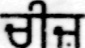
ਚੀਜ਼
